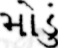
મોડું
